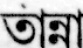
তান্না
